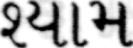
શ્યામ
